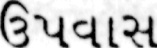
ઉપવાસ
